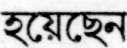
হয়েছেন
